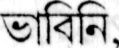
ভাবিনি,
